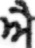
ਐ
